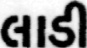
લાડી
